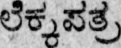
ಲೆಕ್ಕಪತ್ರ
